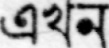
এখন
